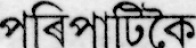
পৰিপাটিকৈ
